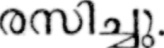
രസിച്ചു.
